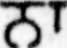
ਨਾ
